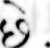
છે.
